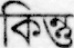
কিন্তু
